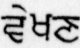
ਵੇਖਣ
